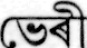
ভেৰী
